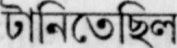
টানিতেছিল
